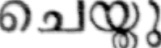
ചെയ്തു
